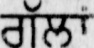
ਗੱਲਾਂ
